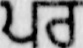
ਪਰ
